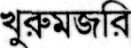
খুরুমজরি
